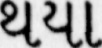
થયા
